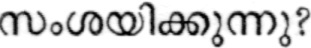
സംശയിക്കുന്നു?
